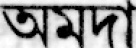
অমদা
